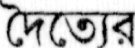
দৈত্যের
